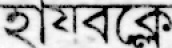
হায়রক্লে
